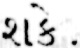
શકે.
